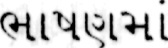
ભાષણમાં
